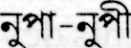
নুপা-নুপী
